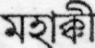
মহাক্কী
